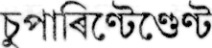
চুপাৰিণ্টেণ্ডেণ্ট
